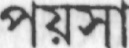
পয়সা
